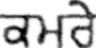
ਕਮਰੇ
